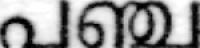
പഞ്ച
